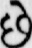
છે
